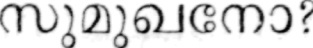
സുമുഖനോ?
